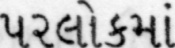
પરલોકમાં
